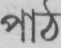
পাঠ
